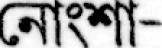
নোংশা-
